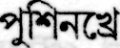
পুশিনখ্রে
